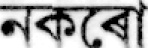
নকৰো
